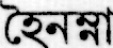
হৈনম্না
